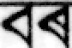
বৰ
